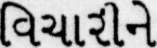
વિચારીને
